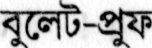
বুলেট-প্রুফ
